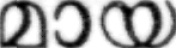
മായ
